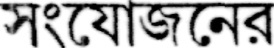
সংযোজনের
